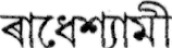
ৰাধেশ্যামী
